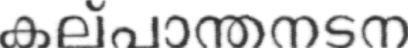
കല്പാന്തനടന
